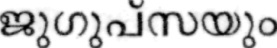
ജുഗുപ്സയും
